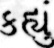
કહ્યું
